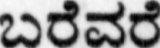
ಬರೆವರೆ
